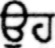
ਉਹ
